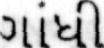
ગાંધી
